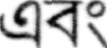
এবং
